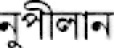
নুপীলান
